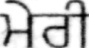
ਮੇਰੀ
